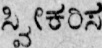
ಸ್ವೀಕರಿಸ
